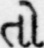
તો
